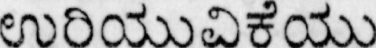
ಉರಿಯುವಿಕೆಯು
